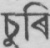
চুৰি
